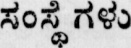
ಸಂಸ್ಥೆಗಳು
